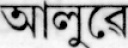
আলুৱে
